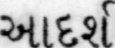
આદર્શ
